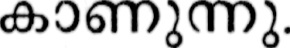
കാണുന്നു.
